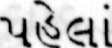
પહેલાં
